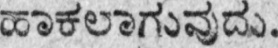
ಹಾಕಲಾಗುವುದು.
